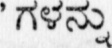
’ಗಳನ್ನು
